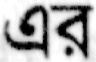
এর
